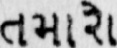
તમારો
